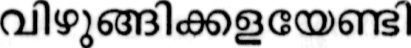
വിഴുങ്ങിക്കളയേണ്ടി
